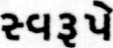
સ્વરૂપે
